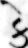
કે
